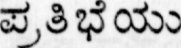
ಪ್ರತಿಭೆಯು
